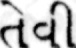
તેવી
